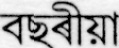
বছৰীয়া
